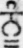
ਨੂੰ
